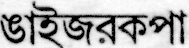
ঙাইজরকপা
